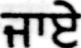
ਜਾਏ
